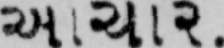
આચાર.
